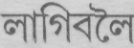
লাগিবলৈ
